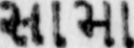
સામા
